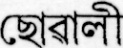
ছোৱালী
